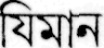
যিমান
